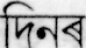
দিনৰ
